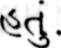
હતું.
